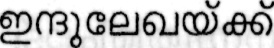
ഇന്ദുലേഖയ്ക്ക്
